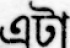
এটা
